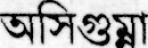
অসিগুম্না
